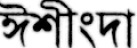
ঈশীংদা
